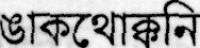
ঙাকথোক্কনি
